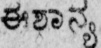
ಈಶಾನ್ಯ
